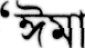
‘ঈমা
